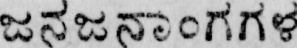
ಜನಜನಾಂಗಗಳ
